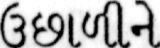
ઉછાળીને
